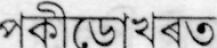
পকীডোখৰত
